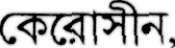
কেরোসীন,
